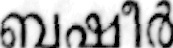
ബഷീര്‍
